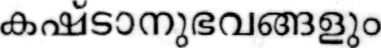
കഷ്ടാനുഭവങ്ങളും
